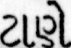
ટાણે
